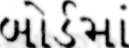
બોર્ડમાં
